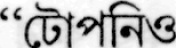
"টোপনিও
